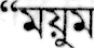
“ময়ুম
